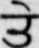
ਤੇ
